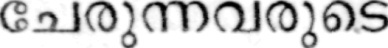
ചേരുന്നവരുടെ
